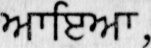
ਆਇਆ,
